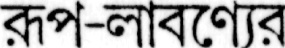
রূপ-লাবণ্যের
